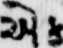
એક
